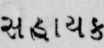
સહાયક
